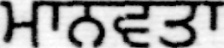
ਮਾਨਵਤਾ
